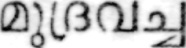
മുദ്രവച്ച
